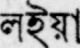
লইয়া
